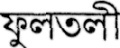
ফুলতলী
